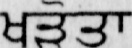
ਖੜੋਤਾ
